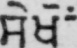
ਸੇਖੋਂ
